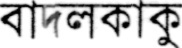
বাদলকাকু
